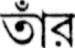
তাঁর
